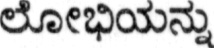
ಲೋಭಿಯನ್ನು
